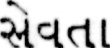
સેવતા
